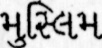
મુસ્લિમ
